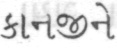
કાનજીને
